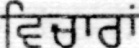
ਵਿਚਾਰਾਂ
